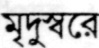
মৃদুস্বরে
